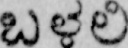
ಬಳಲಿ
